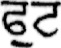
ਫੁਟ
